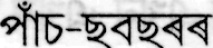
পাঁচ-ছবছৰৰ
